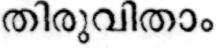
തിരുവിതാം
